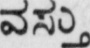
ವಸ್ತು
